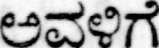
ಅವಳಿಗೆ
